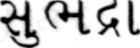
સુભદ્રા
